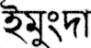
ইমুংদা
